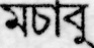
মচাবু
